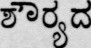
ಶೌರ್‍ಯದ
